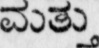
ಮತ್ತು
